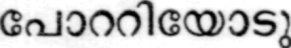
പോററിയോടു
